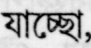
যাচ্ছো,
